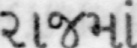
રાજમાં
